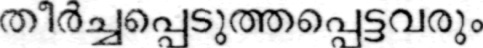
തീര്‍ച്ചപ്പെടുത്തപ്പെട്ടവരും
